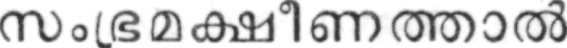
സംഭ്രമക്ഷീണത്താല്‍
